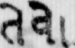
તેવો
